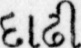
દાઢી
